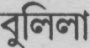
বুলিলা
